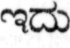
ಇದು
